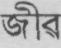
জীৱ
